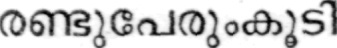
രണ്ടുപേരുംകൂടി
